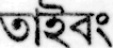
তাইবং
